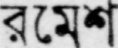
রমেশ
